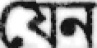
যেন
